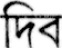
দিব
